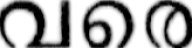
വരെ
